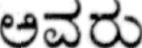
ಅವರು
